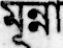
মূন্না
